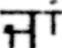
ਜਾਂ
